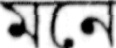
মনে
